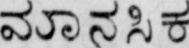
ಮಾನಸಿಕ
